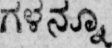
ಗಳನ್ನೂ
